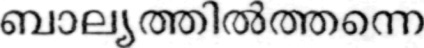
ബാല്യത്തില്‍ത്തന്നെ
